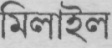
মিলাইল
